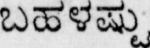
ಬಹಳಷ್ಟು
